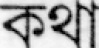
কথা
